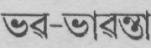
ভৱ-ভাৱন্তা
